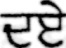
ਦਏ
